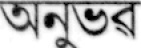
অনুভৱ
